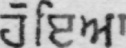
ਹੋਇਆ
